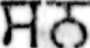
ਸਨ
